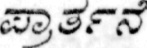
ಪ್ರಾರ್ತನೆ
